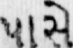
પાસે
